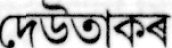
দেউতাকৰ
